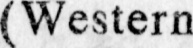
(Western
